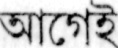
আগেই
